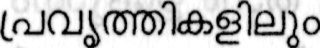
പ്രവൃത്തികളിലും
